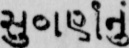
સુવર્ણનું
